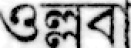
ওল্লবা
